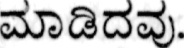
ಮಾಡಿದವು.
